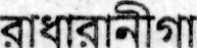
রাধারানীগা
